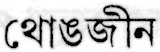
থোঙজীন
